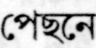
পেছনে
